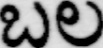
ಬಲ
